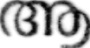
ആ
